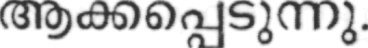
ആക്കപ്പെടുന്നു.
